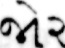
જોર
